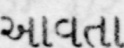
આવતા
